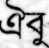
ঐবু
